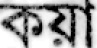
কয়া
